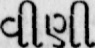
વીણી
